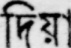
দিয়া
